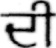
ਦੀ
